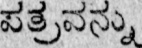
ಪತ್ರವನ್ನು
